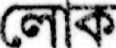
লোক
